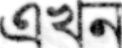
এখন
